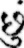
છું
